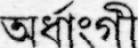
অর্ধাংগী
